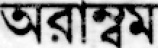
অরাম্বম
